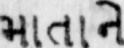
માતાને
